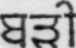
ਬੜੀ
